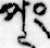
পূং
